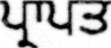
ਪ੍ਰਾਪਤ
